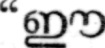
“ഈ
